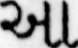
આ
